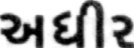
અધીર
